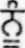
ਨੂੰ
